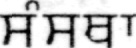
ਸੰਸਥਾ
